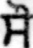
ਸੌ
